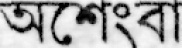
অশেংবা
